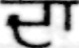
ਦਾ
